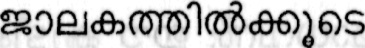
ജാലകത്തില്‍ക്കൂടെ
